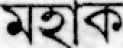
মহাক
